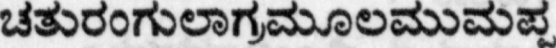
ಚತುರಂಗುಲಾಗ್ರಮೂಲಮುಮಪ್ಪ
